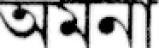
অমনা
